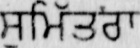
ਸੁਮਿੱਤਰਾ
